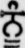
ਨੂੰ
